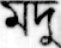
মদু
